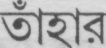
তাঁহার
